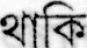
থাকি
